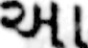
આ
